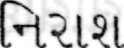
નિરાશ
